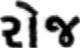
રોજ
